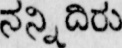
ನನ್ನಿದಿರು
